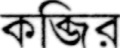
কব্জির
